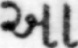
આ
